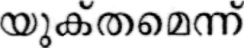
യുക്തമെന്ന്
